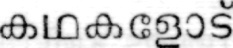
കഥകളോട്
